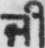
ਜੀ
